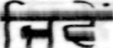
ਜਿਵੇਂ
